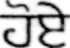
ਹੋਏ
